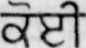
ਕੋਈ
